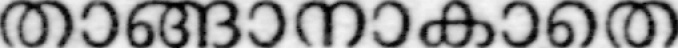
താങ്ങാനാകാതെ
